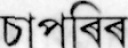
চাপৰিৰ
